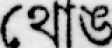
থোঙ
